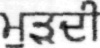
ਮੁੜਦੀ
